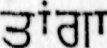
ਤਾਂਗਾ
